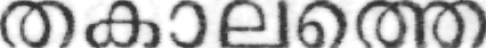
തകാലത്തെ
